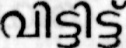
വിട്ടിട്ട്
